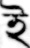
ই
